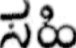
ಸಹಿ
